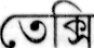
তেক্সি
